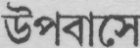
উপবাসে
